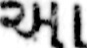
આ
